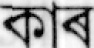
কাৰ
